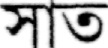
সাত
